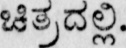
ಚಿತ್ರದಲ್ಲಿ.
